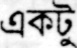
একটু
